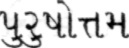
પુરુષોત્તમ
